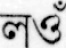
লওঁ
